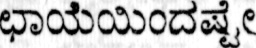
ಛಾಯೆಯಿಂದಷ್ಟೇ
